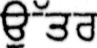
ਉੱਤਰ
